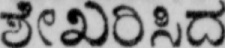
ಶೇಖರಿಸಿದ
